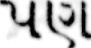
પણ
